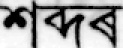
শব্দৰ
